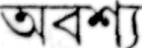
অবশ্য
